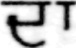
ਦਾ
